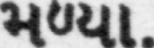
મળ્યા.
